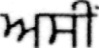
ਅਸੀਂ
